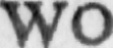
Wo
